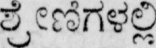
ಶ್ರೇಣಿಗಳಲ್ಲಿ
